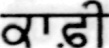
ਕਾਫ਼ੀ
